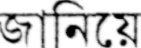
জানিয়ে
